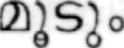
മൂടും
